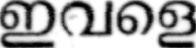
ഇവളെ
